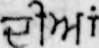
ਦੀਆਂ
